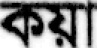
কয়া
